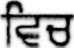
ਵਿਚ
